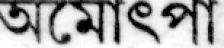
অমোৎপা
